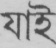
যাই
